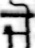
ਜੋ
